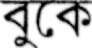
বুকে
